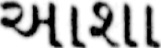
આશા
